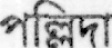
পল্লিদা
